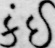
કંઈ
